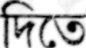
দিতে
